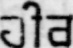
ਹੀਰ
